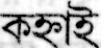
কহ্নাই
